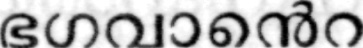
ഭഗവാന്റെ
